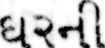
ઘરની
